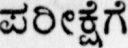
ಪರೀಕ್ಷೆಗೆ
